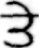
ਤੇ
